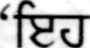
'ਇਹ
